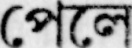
পেলে
